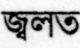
জ্বলত
